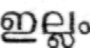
ഇല്ലം
